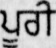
ਪੂਰੀ
